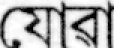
যোৱা
